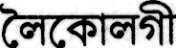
লৈকোলগী
